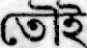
তৌই
